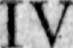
IV
